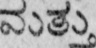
ಮತ್ತು
